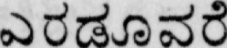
ಎರಡೂವರೆ
